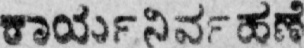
ಕಾರ್ಯನಿರ್ವಹಣೆ
